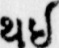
થઈ
